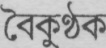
বৈকুণ্ঠক
